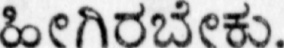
ಹೀಗಿರಬೇಕು.
